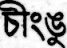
চীংঙু
